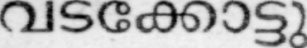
വടക്കോട്ടു
